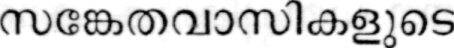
സങ്കേതവാസികളുടെ
